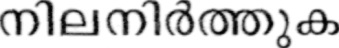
നിലനിര്‍ത്തുക
